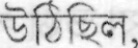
উঠিছিল,
